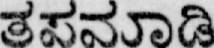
ತಪಮಾಡಿ
